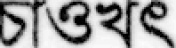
চাওখৎ
